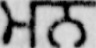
ਮਨ
